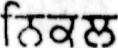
ਨਿਕਲ
